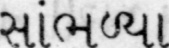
સાંભળ્યા
